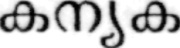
കന്യക
